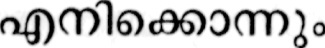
എനിക്കൊന്നും
